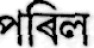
পৰিল
